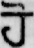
ਹੋ
